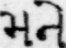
મને
